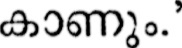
കാണും.’
